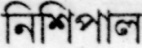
নিশিপাল
